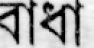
বাধা
